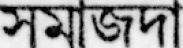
সমাজদা
